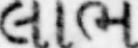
લાભ
